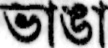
ভাঙা
